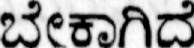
ಬೇಕಾಗಿದೆ
